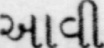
આવી
